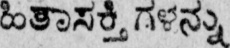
ಹಿತಾಸಕ್ತಿಗಳನ್ನು
